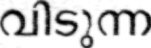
വിടുന്ന
